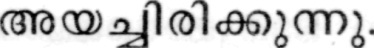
അയച്ചിരിക്കുന്നു.
